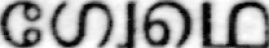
ഗ്വേഥെ
